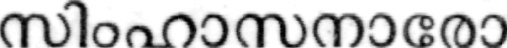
സിംഹാസനാരോ
